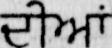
ਦੀਆਂ
